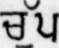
ਚੁੱਪ
